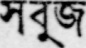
সবুজ
